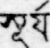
সূর্য
